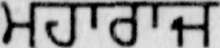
ਮਹਾਰਾਜ
